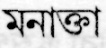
মনাক্তা
